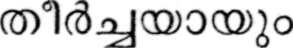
തീര്‍ച്ചയായും
